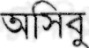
অসিবু
